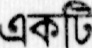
একটি
